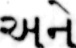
અને
